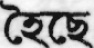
হৈছে
